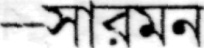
-সারমন
